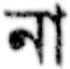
না
